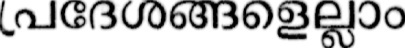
പ്രദേശങ്ങളെല്ലാം
